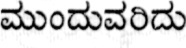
ಮುಂದುವರಿದು
